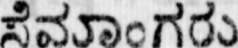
ಸೆಮಾಂಗರು
